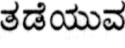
ತಡೆಯುವ
